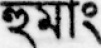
হুমাং
